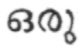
ഒരു
